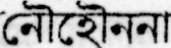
নৌহৌনা
